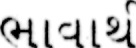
ભાવાર્થ
